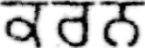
ਕਰਨ
